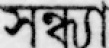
সন্ধ্যা
